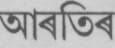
আৰতিৰ
